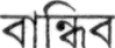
বান্ধিব
